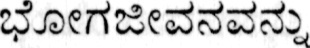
ಭೋಗಜೀವನವನ್ನು
